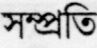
সম্প্রতি
